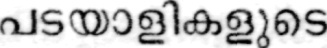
പടയാളികളുടെ
